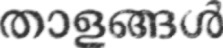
താളങ്ങള്‍
